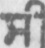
ਸੀ
